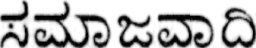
ಸಮಾಜವಾದಿ
